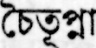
চৈতূপ্না
